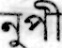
নুপী
